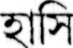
হাসি
